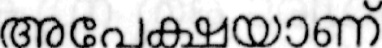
അപേക്ഷയാണ്
